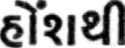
હોંશથી
